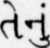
તેનું
